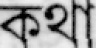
কথা
